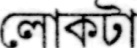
লোকটা
